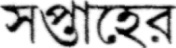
সপ্তাহের
